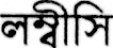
লম্বীসি
